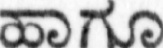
ಹಾಗೂ
